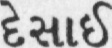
દેસાઈ
